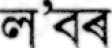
ল'বৰ
